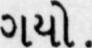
ગયો.
